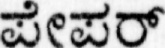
ಪೇಪರ್
